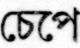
চেপে
